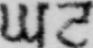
ਘਟ
